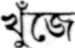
খুঁজে
